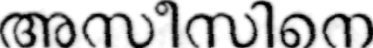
അസീസിനെ
